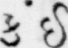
કંઈ
